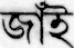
জাঁই
